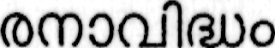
രനാവിദ്ധം
